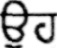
ਉਹ
